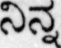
ನಿನ್ನ
